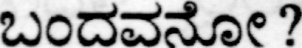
ಬಂದವನೋ?
